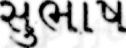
સુભાષ
